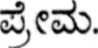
ಪ್ರೇಮ.
